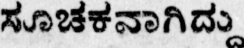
ಸೂಚಕವಾಗಿದ್ದು
